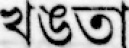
খঙতা
